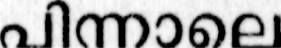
പിന്നാലെ
